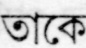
তাকে
